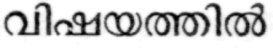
വിഷയത്തില്‍
